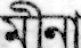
মীনা
